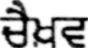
ਚੈਖ਼ਵ
